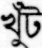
খুঁট
